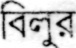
বিলুর
